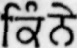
ਕਿੰਨੇ
